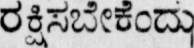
ರಕ್ಷಿಸಬೇಕೆಂದು
